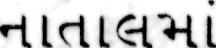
નાતાલમાં
